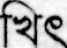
খিৎ
